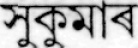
সুকুমাৰ
